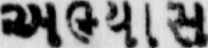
અભ્યાસ
